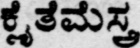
ಕ್ಲೈತೆಮೆಸ್ತ್ರ
